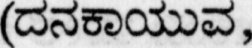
(ದನಕಾಯುವ,
